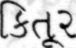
કિતૂર
